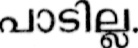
പാടില്ല.
